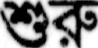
শুরু
